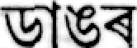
ডাঙৰ
